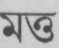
মত্ত
